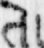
તો
